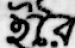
ইরৈ
